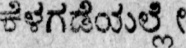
ಕೆಳಗಡೆಯಲ್ಲೇ
